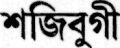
শজিবুগী
